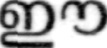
ഈ
